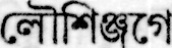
লৌশিঞ্জগে
